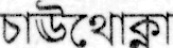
চাঊথোক্না
